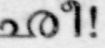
ഛീ!
